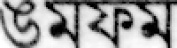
ঙমফম
